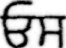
ਓਸ
